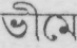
ভীমে
